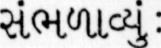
સંભળાવ્યું:
